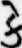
કે
